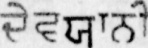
ਦੇਵਯਾਨੀ
